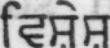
ਵਿਸ਼ੇਸ਼
